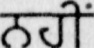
ਨਹੀਂ
